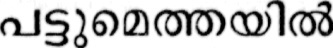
പട്ടുമെത്തയില്‍
